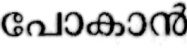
പോകാന്‍
